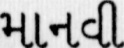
માનવી
